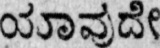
ಯಾವುದೇ
